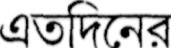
এতদিনের
